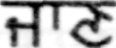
ਜਾਣ
